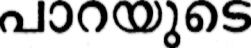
പാറയുടെ
